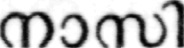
നാസി
